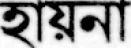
হায়না
